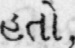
હતો,
